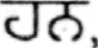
ਹਨ,
